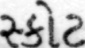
સ્કોટ
